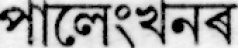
পালেংখনৰ
